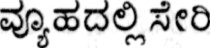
ವ್ಯೂಹದಲ್ಲಿಸೇರಿ
